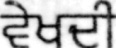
ਵੇਖਦੀ
